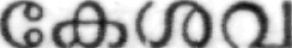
കേശവ
